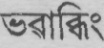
ভৱাব্ধিং
